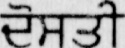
ਦੋਸਤੀ
